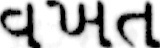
વખત
